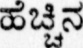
ಹೆಚ್ಚಿನ
